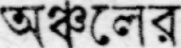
অঞ্চলের
